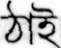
ঠাই
